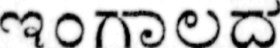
ಇಂಗಾಲದ
